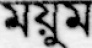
ময়ুম
